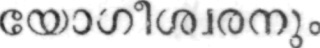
യോഗീശ്വരനും
